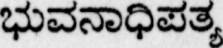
ಭುವನಾಧಿಪತ್ಯ
